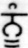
ਨੂੰ
